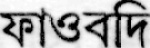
ফাওবদি
